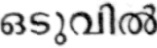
ഒടുവില്‍
